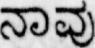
ನಾವು
